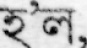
হ'ল,
